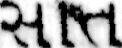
સાત
